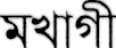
মখাগী
